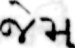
જેમ
